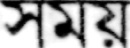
সময়
